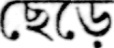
ছেড়ে
